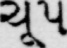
ચૂપ
